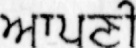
ਆਪਣੀ
